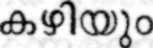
കഴിയും
